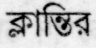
ক্লান্তির
